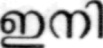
ഇനി
